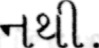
નથી.
